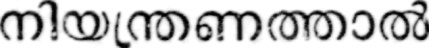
നിയന്ത്രണത്താല്‍
